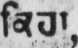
ਕਿਹਾ,
